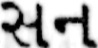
સન
